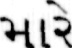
મારે
